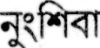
নুংশিবা
